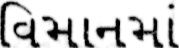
વિમાનમાં
